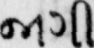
જાગી
